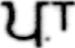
ਪਾ
